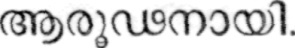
ആരൂഢനായി.
